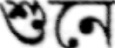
শুনে
